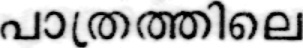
പാത്രത്തിലെ
